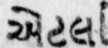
એટલાં
